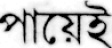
পায়েই
